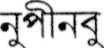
নুপীনবু
